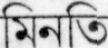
মিনতি
